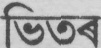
ভিতৰ
